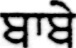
ਬਾਬੇ
